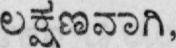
ಲಕ್ಷಣವಾಗಿ,
